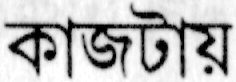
কাজটায়
